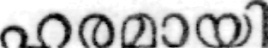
ഹരമായി
